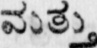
ಮತ್ತು
